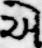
એ
